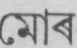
মোৰ
